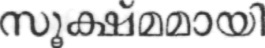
സൂക്ഷ്മമായി
